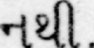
નથી.
